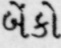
બેંકો
